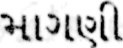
માગણી
